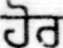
ਹੋਰ
